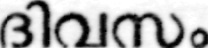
ദിവസം
